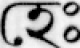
হেঃ
